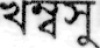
খম্বসু
